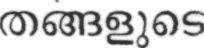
തങ്ങളുടെ
